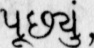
પૂછ્યું,
